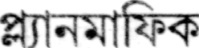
প্ল্যানমাফিক
